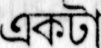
একটা
